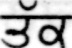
ਤੱਕ
